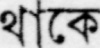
থাকে
